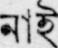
নাই
